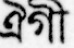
ঐগী
